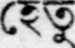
হেতু
